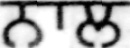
ਨਾਲ
